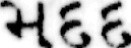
મદદ
